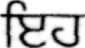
ਇਹ
